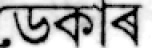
ডেকাৰ
